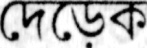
দেড়েক
